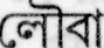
লৌবা
